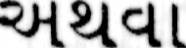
અથવા
